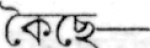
কৈছে-
